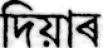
দিয়াৰ
